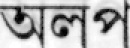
অলপ
